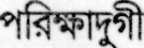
পরিক্ষাদুগী
